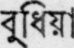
বুধিয়া
